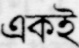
একই
